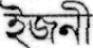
ইজনী
